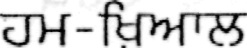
ਹਮ-ਖ਼ਿਆਲ
